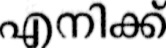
എനിക്ക്
